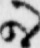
જે
